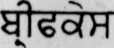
ਬ੍ਰੀਫਕੇਸ
